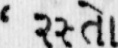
'રસ્તો
